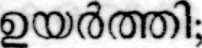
ഉയര്‍ത്തി;
